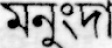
মনুংদা
